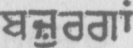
ਬਜ਼ੁਰਗਾਂ
